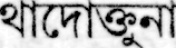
থোদোক্তুনা
